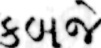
કબજે
